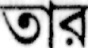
তার
